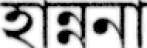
হান্ননা
